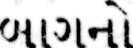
બાગનો
